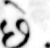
છે.
